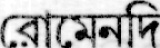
রোমেনদি
